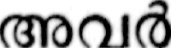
അവര്‍
